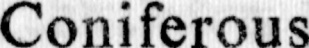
Coniferous
